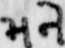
મને
